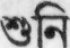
শুনি
